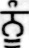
ਨੂੰ
